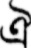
ঐ
